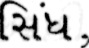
સિંધ,
